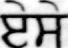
ਏਸੇ
